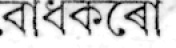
বোধকৰো
